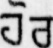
ਹੋਰ
